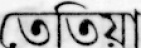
তেতিয়া
